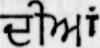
ਦੀਆਂ
